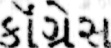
કૉંગ્રેસ
